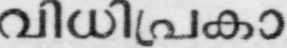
വിധിപ്രകാ
